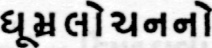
ધૂમ્રલોચનનો
